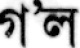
গ'ল
